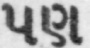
પણ
